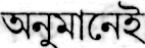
অনুমানেই
